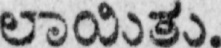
ಲಾಯಿತು.
